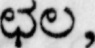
ಛಲ,
